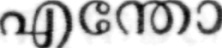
എന്തോ
